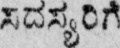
ಸದಸ್ಯರಿಗೆ
